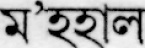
ম'হহাল
